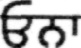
ਓਨਾ
